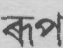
ৰূপ
